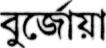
বুর্জোয়া
